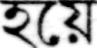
হয়ে
